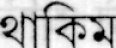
থাকিম
